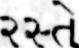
રસ્તે
